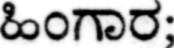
ಹಿಂಗಾರ;
